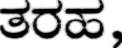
ತರಹ,
